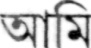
আমি
